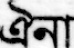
ঐনা
